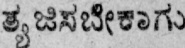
ತ್ಯಜಿಸಬೇಕಾಗು
